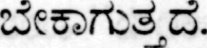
ಬೇಕಾಗುತ್ತದೆ.
